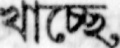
খাচ্ছে,
